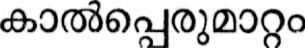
കാല്‍പ്പെരുമാറ്റം
